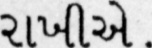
રાખીએ.
